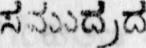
ಸಮುದ್ರದ
